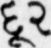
દૂર
